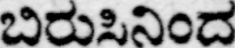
ಬಿರುಸಿನಿಂದ
